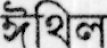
ঈথিল
